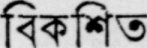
বিকশিত
